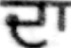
ਦਾ
